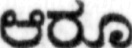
ಆರೂ
